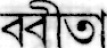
ববীতা
